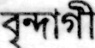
বৃন্দাগী
